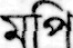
মপি
